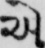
એ
